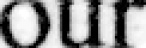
our
